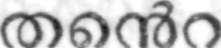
തന്റെ
